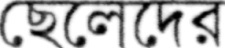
ছেলেদের
